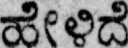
ಹೇಳಿದೆ
